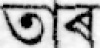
তাৰ
